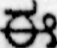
ಈ
